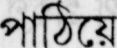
পাঠিয়ে
